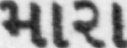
મારા
